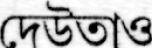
দেউতাও
